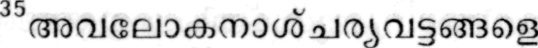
35അവലോകനാശ്ചര്യവട്ടങ്ങളെ
